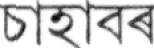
চাহাবৰ
